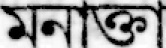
মনাক্তা
